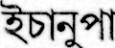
ইচানুপা
